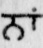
ਨਾਂ
